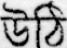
উঠি
